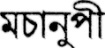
মচানুপী
